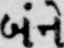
બંને
